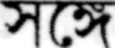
সঙ্গে
